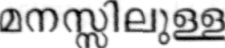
മനസ്സിലുള്ള
